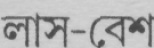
লাস-বেশ
